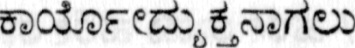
ಕಾರ್ಯೋದ್ಯುಕ್ತನಾಗಲು
